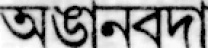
অঙানবদা
